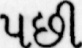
પછી
